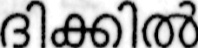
ദിക്കില്‍
